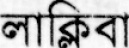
লাক্লিবা
